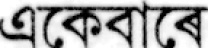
একেবাৰে
